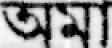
অমা
